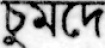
চুমদে
